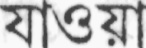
যাওয়া
